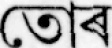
তোৰ
